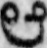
ಆ
